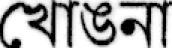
খোঙনা
